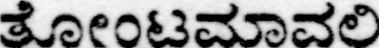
ತೋಂಟಮಾವಲಿ
